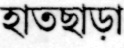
হাতছাড়া
